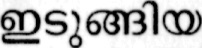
ഇടുങ്ങിയ
